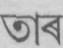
তাৰ
